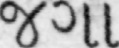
જગા
